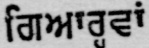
ਗਿਆਰ੍ਹਵਾਂ
